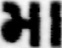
મા
